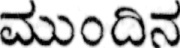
ಮುಂದಿನ
